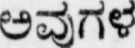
ಅವುಗಳ
